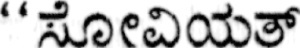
"ಸೋವಿಯತ್
